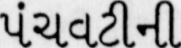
પંચવટીની
